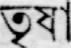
তৃষা
